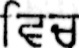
ਵਿਚ
